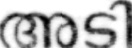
അടി
